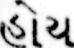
હોય
